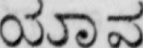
ಯಾವ
